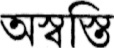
অস্বস্তি
